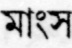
মাংস
